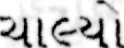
ચાલ્યો
